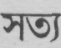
সত্য
